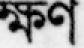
ক্ষণ
